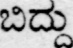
ಬಿದ್ದು
